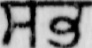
ਸਭ
